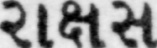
રાક્ષસ
